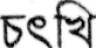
চৎখি
